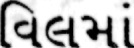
વિલમાં
